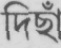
দিছাঁ
